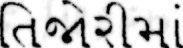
તિજોરીમાં
